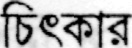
চিৎকার
